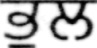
ਭੁਲ
